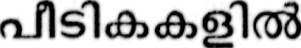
പീടികകളില്‍
